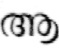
ആ
